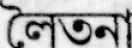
লৈতনা
